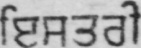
ਇਸਤਰੀ
